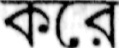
করে
